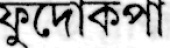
ফুদোকপা
